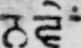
ਨਵੇਂ
